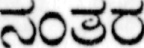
ನಂತರ
